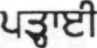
ਪੜ੍ਹਾਈ
